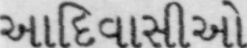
આદિવાસીઓ
